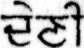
ਦੇਣੀ
